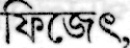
ফিজেৎ,
